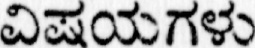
ವಿಷಯಗಳು
